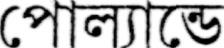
পোল্যান্ডে
